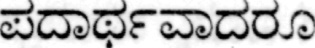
ಪದಾರ್ಥವಾದರೂ
